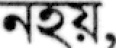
নহয়,
